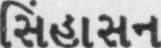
સિંહાસન
